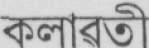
কলাৱতী
